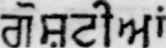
ਗੋਸ਼ਟੀਆਂ
